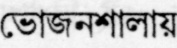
ভোজনশালায়
